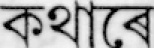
কথাৰে
